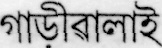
গাড়ীৱালাই
